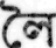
লৈ
